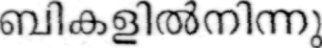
ബികളില്‍നിന്നു
